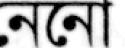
নেনো
